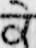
ਕੇ
